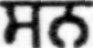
ਸਨ
